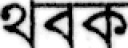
থবক
